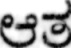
ಆತ
